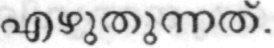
എഴുതുന്നത്.
